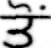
ਤੋਂ
